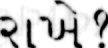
રાખે?
